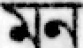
মন
